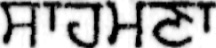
ਸਾਹਮਣਾ
